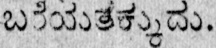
ಬರೆಯತಕ್ಕುದು.
